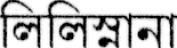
লিলিস্নানা
